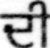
ਦੀ
